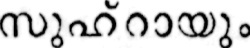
സുഹ്റായും
